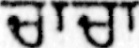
ਚਾਚਾ
